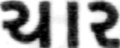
ચાર
